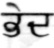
ਭੇਦ
